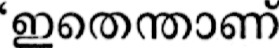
‘ഇതെന്താണ്
